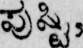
ಪುಷ್ಟಿ,
